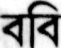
ববি
